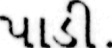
પાડી.
